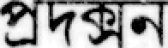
প্রদক্সন
